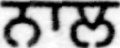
ਨਾਲ
